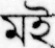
মই
